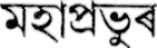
মহাপ্রভুৰ
